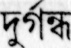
দুর্গন্ধ
